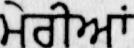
ਮੇਰੀਆਂ
